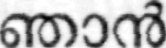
ഞാന്‍
